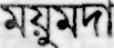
ময়ুমদা
